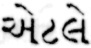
એટલે
